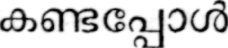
കണ്ടപ്പോള്‍
